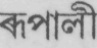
ৰূপালী
